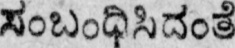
ಸಂಬಂಧಿಸಿದಂತೆ
